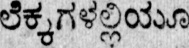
ಲೆಕ್ಕಗಳಲ್ಲಿಯೂ
